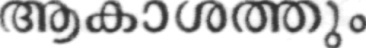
ആകാശത്തും
